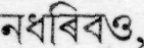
নধৰিবও,
